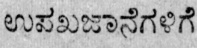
ಉಪಖಜಾನೆಗಳಿಗೆ
